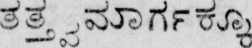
ತತ್ತ್ವಮಾರ್ಗಕ್ಕೂ
